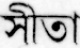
সীতা
